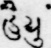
હૈયું
